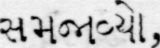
સમજાવ્યો,
